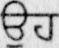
ਉਹ
